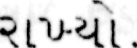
રાખ્યો.
